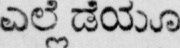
ಎಲ್ಲೆಡೆಯೂ
